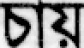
চায়
